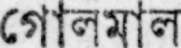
গোলমাল
